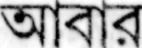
আবার
